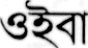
ওইবা
